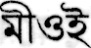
মীওই
